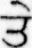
ਤੇ
